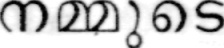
നമ്മുടെ
